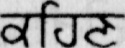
ਕਹਿਣ
